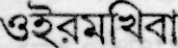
ওইরমখিবা
